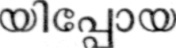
യിപ്പോയ
